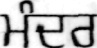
ਮੰਦਰ
